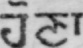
ਹੋਣਾ
